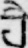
ਹੈ
